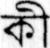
কী
